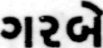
ગરબે
